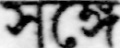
সঙ্গে
